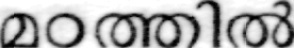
മംത്തില്‍
